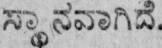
ಸ್ಥಾನವಾಗಿದೆ.
